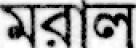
মরাল
